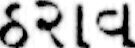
ઠરાવ
